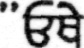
''ਓਥੇ
